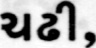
ચઢી,
